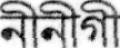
নীনীগী
